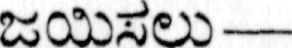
ಜಯಿಸಲು-
